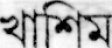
খাশিম
